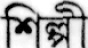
শিল্পী
